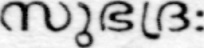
സുഭദ്ര:
